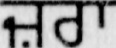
ਜ਼ਰਾ
